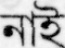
নাই
